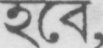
হবে,
